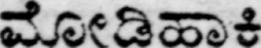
ಮೋಡಿಹಾಕಿ
